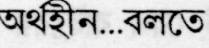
অর্থহীন...বলতে
